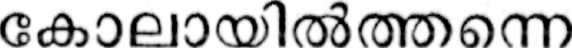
കോലായില്‍ത്തന്നെ
